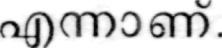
എന്നാണ്.
